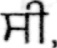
ਸੀ,
